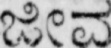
ಜೀವ
